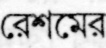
রেশমের
